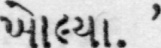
ખોલ્યા.'
